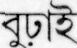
বুঢ়াই
